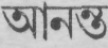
আনন্ত
